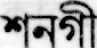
শনগী
